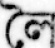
লৈ
